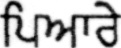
ਪਿਆਰੇ
